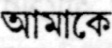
আমাকে
